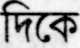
দিকে
